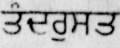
ਤੰਦਰੁਸਤ
